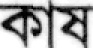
কাষ
